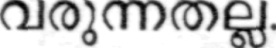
വരുന്നതല്ല.
